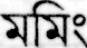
মমিং
